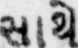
સાથે
